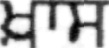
ਖ਼ਾਸ
